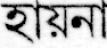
হায়না
